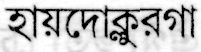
হায়দোক্লুরগা
